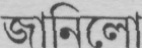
জানিলো
